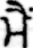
ਮੈਂ
